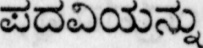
ಪದವಿಯನ್ನು
